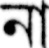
না
